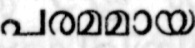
പരമമായ
